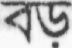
বড়
